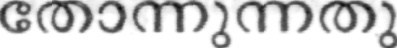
തോന്നുന്നതു
